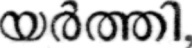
യര്‍ത്തി,
